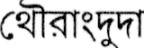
থৌরাংদুদা
